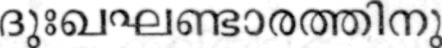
ദുഃഖഘണ്ടാരത്തിനു
